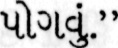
પોગવું."
